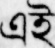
এই
